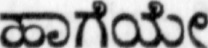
ಹಾಗೆಯೇ
